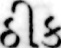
ઠીક
